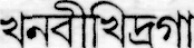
খনবীখিদ্রগা
